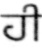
ਹੀ
